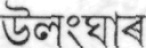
উলংঘাৰ
